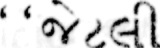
"જેટલી
